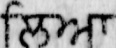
ਲਿਆ
